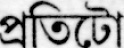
প্রতিটো
